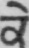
ਕੇ
